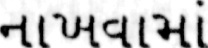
નાખવામાં
